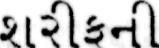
શરીફની
